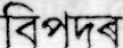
বিপদৰ
